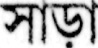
সাড়া
